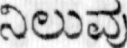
ನಿಲುವು
